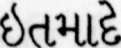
ઇતમાદે
